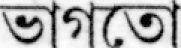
ভাগতো
